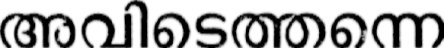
അവിടെത്തന്നെ
